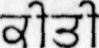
ਕੀਤੀ
